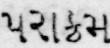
પરાક્રમ
